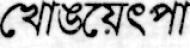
খোঙয়েৎপা
